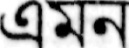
এমন
